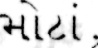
મોટાં,
